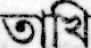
তাখি
